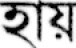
হায়
